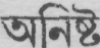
অনিষ্ট
